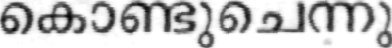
കൊണ്ടുചെന്നു
